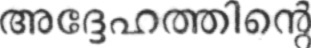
അദ്ദേഹത്തിന്റെ
